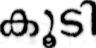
കൂടി
